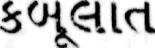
કબૂલાત
